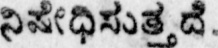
ನಿಷೇಧಿಸುತ್ತದೆ.
